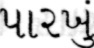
પારખું
